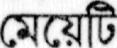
মেয়েটি
